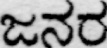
ಜನರ
